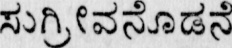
ಸುಗ್ರೀವನೊಡನೆ
